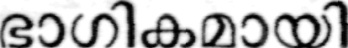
ഭാഗികമായി
